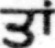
ਤਾਂ
